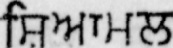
ਸ਼ਿਆਮਲ
